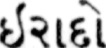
ઇરાદો
